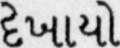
દેખાયો
